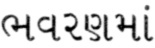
ભવરણમાં
